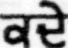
ਕਦੇ
